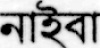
নাইবা
